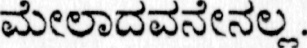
ಮೇಲಾದವನೇನಲ್ಲ.
